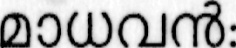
മാധവന്‍:
